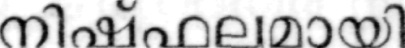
നിഷ്ഫലമായി
